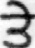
ਤੇ
